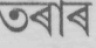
তৰাৰ
